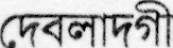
দেবলাগী
